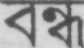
বন্ধ
